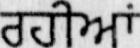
ਰਹੀਆਂ
